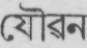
যৌৱন
